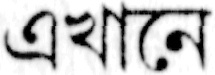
এখানে
